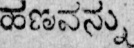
ಹಣವನ್ನು
